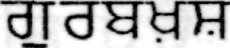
ਗੁਰਬਖ਼ਸ਼
